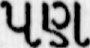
પણ
